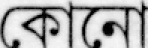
কোনো
